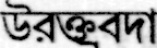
উরক্ত্রবদা
